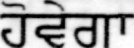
ਹੋਵੇਗਾ
